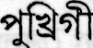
পুখ্রিগী
